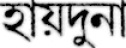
হায়দুনা
